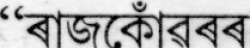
"ৰাজকোঁৱৰৰ
